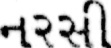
નરસી
